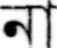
না
